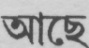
আছে
